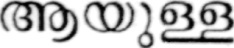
ആയുള്ള
